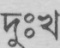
দুঃখ
